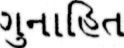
ગુનાહિત
